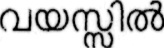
വയസ്സില്‍
